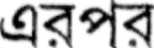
এরপর
